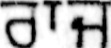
ਰਾਜ
